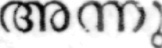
അന്നു
